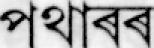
পথাৰৰ
